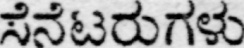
ಸೆನೆಟರುಗಳು
